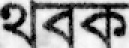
থবক
